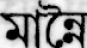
মান্নৈ
